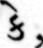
કે,
